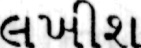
લખીશ
